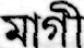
মাগী
